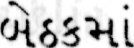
બેઠકમાં
